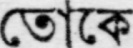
তোকে
